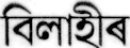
বিলাহীৰ
